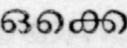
ഒക്കെ
